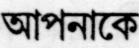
আপনাকে
